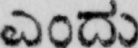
ಎಂದು
